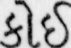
કોઈ
